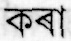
কৰা
